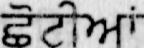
ਛੋਟੀਆਂ
